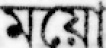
ময়ো
